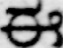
ಈ
